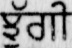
ਝੁੱਗੀ
